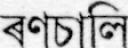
ৰণচালি
